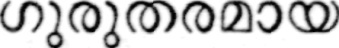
ഗുരുതരമായ
